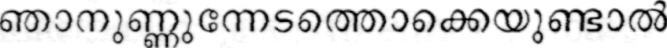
ഞാനുണ്ണന്നേടത്തൊക്കെയുണ്ടാല്‍
